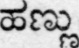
ಹಣ್ಣು
